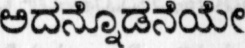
ಅದನ್ನೊಡನೆಯೇ
